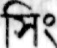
সিং
